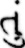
તું
